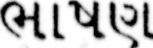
ભાષણ
